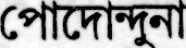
পোদোন্দুনা
